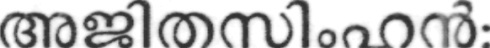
അജിതസിംഹന്‍:
